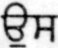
ਉਸ
